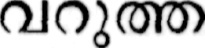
വറുത്ത
